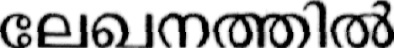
ലേഖനത്തില്‍
